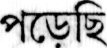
পড়েছি
